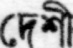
দেশী
